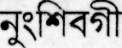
নুংশিবগী
